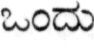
ಒಂದು
